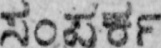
ಸಂಪರ್ಕ
